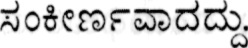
ಸಂಕೀರ್ಣವಾದದ್ದು.
